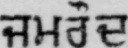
ਜਮਰੌਦ
